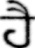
ਹੈ
